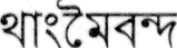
থাংমৈবন্দ
